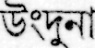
উংদুনা
